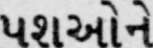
પશઓને
